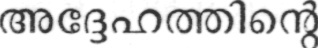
അദ്ദേഹത്തിന്റെ
